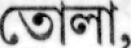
তোলা,
